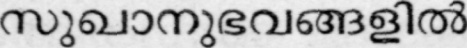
സുഖാനുഭവങ്ങളില്‍
